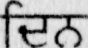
ਦਿਨ
